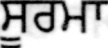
ਸੂਰਮਾ
